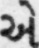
એ
